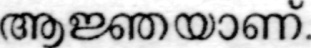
ആജ്ഞയാണ്.
